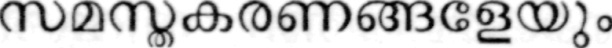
സമസ്തകരണങ്ങളേയും
